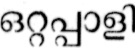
ഒറ്റപ്പാളി
